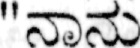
“ನಾನು
